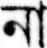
না
